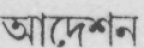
আদেশন
